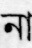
না
